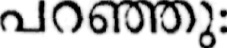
പറഞ്ഞു:
